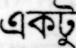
একটু
